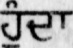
ਹੁੰਦਾ
